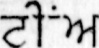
ਟੀਂਅ
